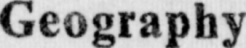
Geography
